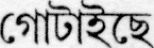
গোটাইছে
